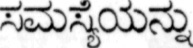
ಸಮಸ್ಯೆಯನ್ನು
